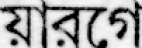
য়ারগে
